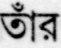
তাঁর
